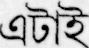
এটাই
